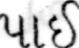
પાઈ
